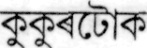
কুকুৰটোক
